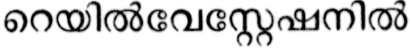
റെയില്‍വേസ്റ്റേഷനില്‍
